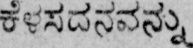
ಕೆಳಸದನವನ್ನು
